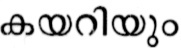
കയറിയും
